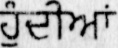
ਹੁੰਦੀਆਂ
